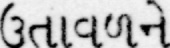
ઉતાવળને
